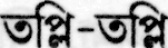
তপ্লি-তপ্লি
